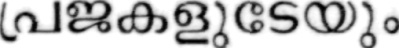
പ്രജകളുടേയും
